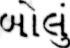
બોલું
